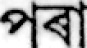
পৰা
